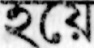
হয়ে
